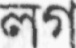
লগ
